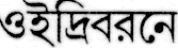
ওইদ্রিবরনে
